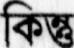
কিন্তু
